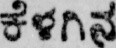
ಕೆಳಗಿನ
